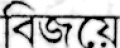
বিজয়ে
